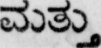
ಮತ್ತು
